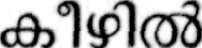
കീഴില്‍
